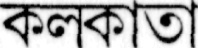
কলকাতা
